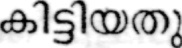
കിട്ടിയതു
